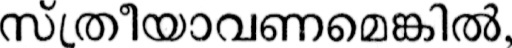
സ്ത്രീയാവണമെങ്കില്‍,
